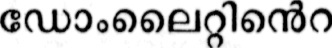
ഡോംലൈറ്റിന്റെ
